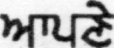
ਆਪਣੇ
